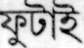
ফুটাই
